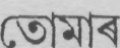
তোমাৰ
